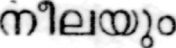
നീലയും
